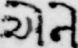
એને
